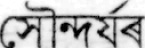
সৌন্দর্যৰ
